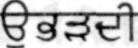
ਉਭੜਦੀ
